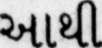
આથી
